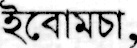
ইবোমচা,
